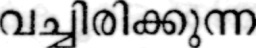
വച്ചിരിക്കുന്ന
